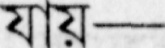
যায়-
